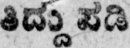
ತಿದ್ದುಪಡಿ
